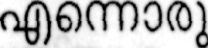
എന്നൊരു
